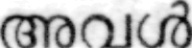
അവള്‍
